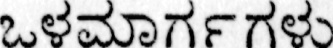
ಒಳಮಾರ್ಗಗಳು
